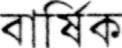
বার্ষিক
